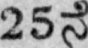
25ನೆ
